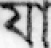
যা
